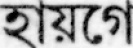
হায়গে
